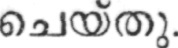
ചെയ്തു.
